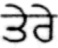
ਤੇਰੇ
